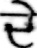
ਦੇ
